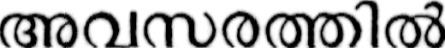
അവസരത്തില്‍
